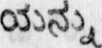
ಯನ್ನು
